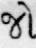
જો
